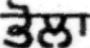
ਭੋਲਾ
